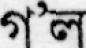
গ'ল
